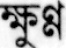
ক্ষুণ্ণ
